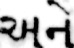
અને
